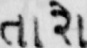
તારો
